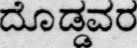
ದೊಡ್ಡವರ
